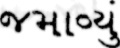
જમાવ્યું
